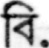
বি.
